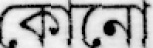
কোনো
